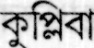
কুপ্লিবা
